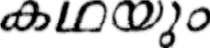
കഥയും
